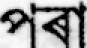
পৰা
